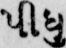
પીધુ
